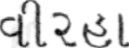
વીરહા
